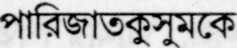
পারিজাতকুসুমকে
